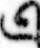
এ
